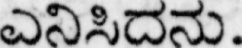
ಎನಿಸಿದನು.
